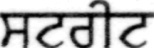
ਸਟਰੀਟ
